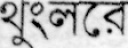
থুংলরে
